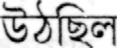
উঠছিল
